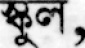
স্কুল,
